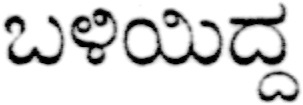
ಬಳಿಯಿದ್ದ
